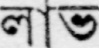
লাভ
